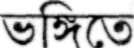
ভঙ্গিতে
